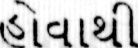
હોવાથી
